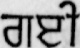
ਗਈ
